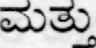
ಮತ್ತು
